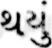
થયું
